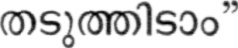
തടുത്തിടാം”
